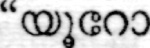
“യൂറോ
